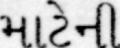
માટેની
